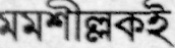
মমশীল্লকই
